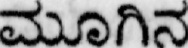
ಮೂಗಿನ
